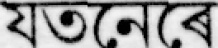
যতনেৰে
